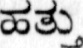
ಹತ್ತು
